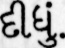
દીધું.
